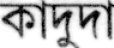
কাদুদা
